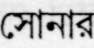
সোনার
